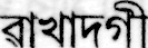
ৱাখাদগী
